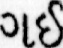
ગઈ
